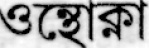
ওন্থোক্না
